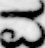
ವ
